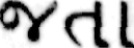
જતા
